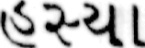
હસ્યા
